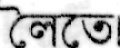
লৈতে।
